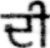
ਦੀ
